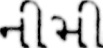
નીમી
